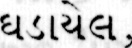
ઘડાયેલ,
